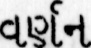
વર્ણન
